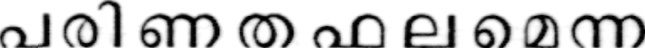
പരിണതഫലമെന്ന
